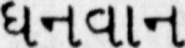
ધનવાન
